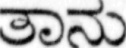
ತಾನು
